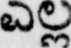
ಎಲ್ಲ
